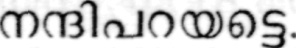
നന്ദിപറയട്ടെ.
